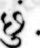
છું.
